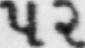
પર
